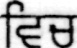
ਵਿਚ
